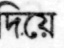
দিয়ে
